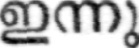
ഇന്നു
